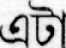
এটা
